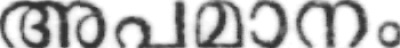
അപമാനം
